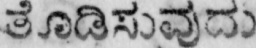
ತೊಡಿಸುವುದು
